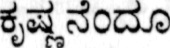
ಕೃಷ್ಣನೆಂದೂ
